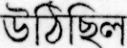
উঠিছিল
